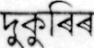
দুকুৰিৰ
